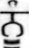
ਨੂੰ
